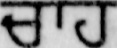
ਚਾਹ
